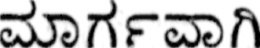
ಮಾರ್ಗವಾಗಿ
